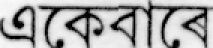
একেবাৰে
